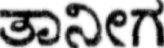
ತಾನೀಗ
